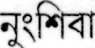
নুংশিবা
